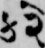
કરે
